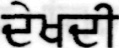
ਦੇਖਦੀ
